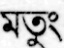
মতুং
